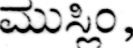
ಮುಸ್ಲಿಂ,
